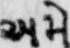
અમે
